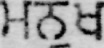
ਮਨੁਖ
